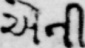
એની
